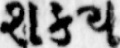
શક્ય
